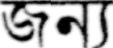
জন্য
